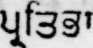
ਪ੍ਰਤਿਭਾ
